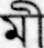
মী
